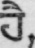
ਹੈ,
